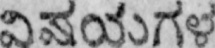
ವಿಷಯಗಳ
